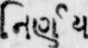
નિર્ણય
